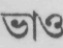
ভাও
